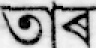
তাৰ
